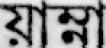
য়াম্না
